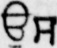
ਉਸ
